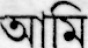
আমি
